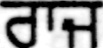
ਰਾਜ
